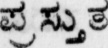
ಪ್ರಸ್ತುತ
